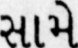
સામે
